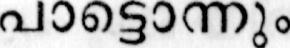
പാട്ടൊന്നും
